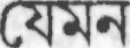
যেমন
